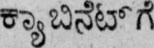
ಕ್ಯಾಬಿನೆಟ್‌ಗೆ
